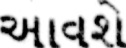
આવશે
